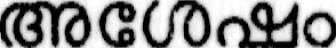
അശേഷം
